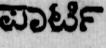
ಪಾರ್ಟಿ
